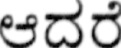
ಆದರೆ
